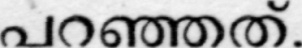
പറഞ്ഞത്.
